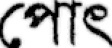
পোৎ
